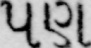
પણ
